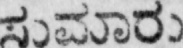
ಸುಮಾರು
